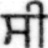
ਸੀ
